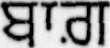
ਬਾਗ਼
